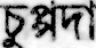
চুপ্পদা
